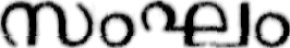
സംഘം
